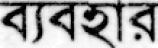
ব্যবহার
